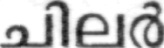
ചിലര്‍
